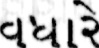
વધારે
